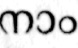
നാം
